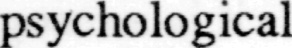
psychological
